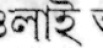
ওলাই
